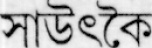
সাউৎকৈ
